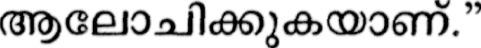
ആലോചിക്കുകയാണ്.”
